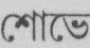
শোভে
